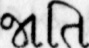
જાતિ
